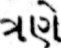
ત્રણે
